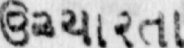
ઉચ્ચારતા
